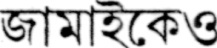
জামাইকেও
